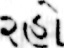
રહો
